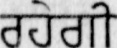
ਰਹੇਗੀ
